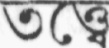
তত্ত্বে
